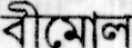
বীমোল
